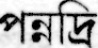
পন্নদ্রি
